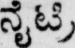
ನೈಟ್ರಿ
